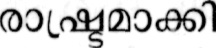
രാഷ്ട്രമാക്കി
